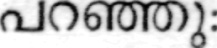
പറഞ്ഞു:
